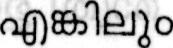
എങ്കിലും
